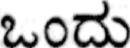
ಒಂದು
